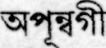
অপূন্বগী
